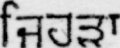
ਜਿਹੜਾ
